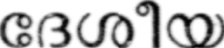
ദേശീയ
